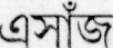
এসাঁজ
